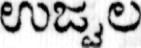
ಉಜ್ವಲ
